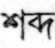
শব্দ
